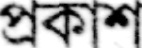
প্রকাশ
